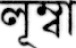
লূম্বা
